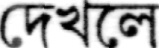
দেখলে
